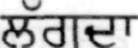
ਲੱਗਦਾ
